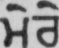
ਮੇਰੇ
